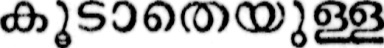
കൂടാതെയുള്ള
